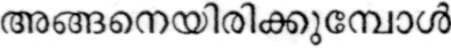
അങ്ങനെയിരിക്കുമ്പോള്‍
